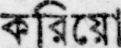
করিয়ো
